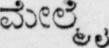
ಮೇಲ್ಮೈ
